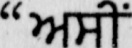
''ਅਸੀਂ
